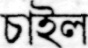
চাইল
